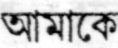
আমাকে
